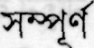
সম্পূর্ণ
